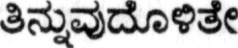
ತಿನ್ನುವುದೊಳಿತೇ
